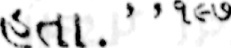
હતા."૧૯૭
